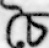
চৈ
